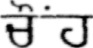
ਚੌਂਹ
